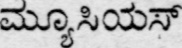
ಮ್ಯೂಸಿಯಸ್
